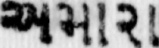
અમારા
